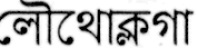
লৌথোক্লগা
